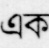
এক
